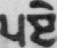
ਪਏ
